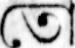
তো
